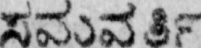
ಸಮವರ್ತಿ
